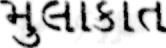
મુલાકાત
